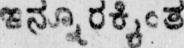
ಇನ್ನೂರಕ್ಕಿಂತ
